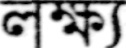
লক্ষ্য
